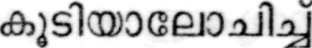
കൂടിയാലോചിച്ച്
